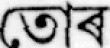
তোৰ
